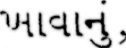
ખાવાનું,
